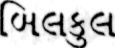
બિલકુલ
